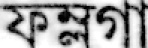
ফম্লগা
